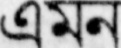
এমন
